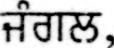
ਜੰਗਲ,
